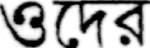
ওদের
